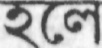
হলে
